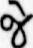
જે
